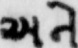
અને
